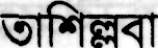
তাশিল্লবা
